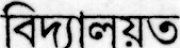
বিদ্যালয়ত
